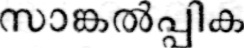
സാങ്കല്‍പ്പിക
